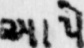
આપે
